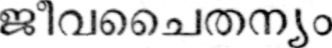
ജീവചൈതന്യം
